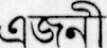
এজনী
